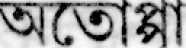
অতোপ্পা
